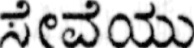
ಸೇವೆಯು
